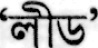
'লীড'
